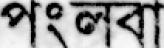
পংলবা
